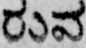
ರುವ
